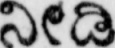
ನೀಡಿ
